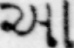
આ
